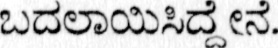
ಬದಲಾಯಿಸಿದ್ದೇನೆ.
